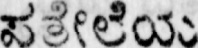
ಪತೇಲೆಯ
